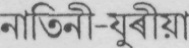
নাতিনী-যুৰীয়া
